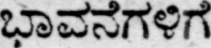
ಭಾವನೆಗಳಿಗೆ
